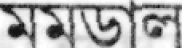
মমডাল
